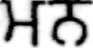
ਮਨ
